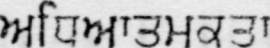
ਅਧਿਆਤਮਕਤਾ
